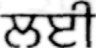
ਲਈ
